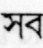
সব
